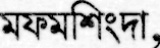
মফমশিংদা,
